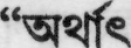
"অর্থাৎ
